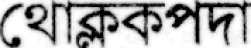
থোক্লকপদা
